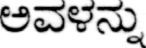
ಅವಳನ್ನು
